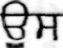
ਉਸ
